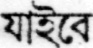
যাইবে
